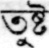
তুষ্ট
